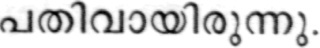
പതിവായിരുന്നു.
